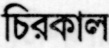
চিরকাল
